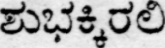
ಶುಭಕ್ಕಿರಲಿ
